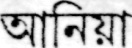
আনিয়া
